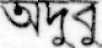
অদুবু
